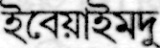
ইবেয়াইমদু
